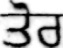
ਤੋਰ
